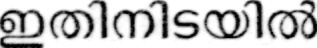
ഇതിനിടയില്‍
